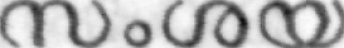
സംശയ
